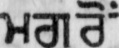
ਮਗਰੋਂ
